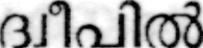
ദ്വീപില്‍
